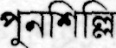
পুনশিল্লি
